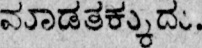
ಮಾಡತಕ್ಕುದು.
